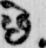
છે.
